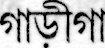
গাড়ীগা
